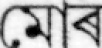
মোৰ
